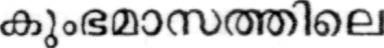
കുംഭമാസത്തിലെ
